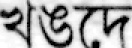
খঙদে
